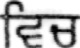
ਵਿਚ
